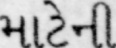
માટેની
